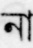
না
